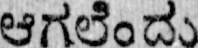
ಆಗಲೆಂದು
